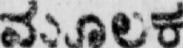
ಮೂಲಕ
